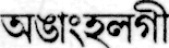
অঙাংহলগী
